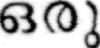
ഒരു
